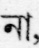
না,
